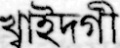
খ্বাইদগী
